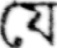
যে
